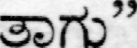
ತಾಗು”
